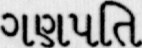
ગણપતિ
